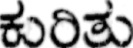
ಕುರಿತು
